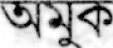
অমুক
